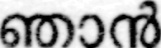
ഞാന്‍
